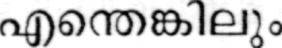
എന്തെങ്കിലും
